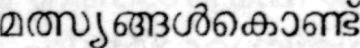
മത്സ്യങ്ങള്‍കൊണ്ട്
